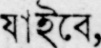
যাইবে,
